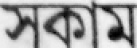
সকাম
